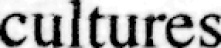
cultures
